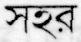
সহর
